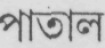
পাতাল
